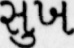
સુખ
